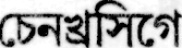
চেনখ্রসিগে
